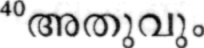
40അതുവും
